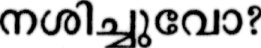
നശിച്ചുവോ?
